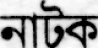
নাটক
